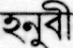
হনুবী
